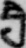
ਹੈ
